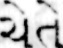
ચેતે
